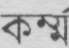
কৰ্ম্ম
